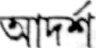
আদর্শ
